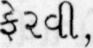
ફેરવી,
